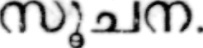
സൂചന.
